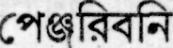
পেঞ্জরিবনি
